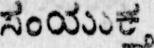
ಸಂಯುಕ್ತ
